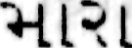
મારા
